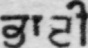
ਭਾਈ
